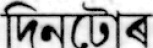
দিনটোৰ
